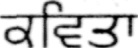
ਕਵਿਤਾ
